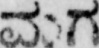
ಮಗ
